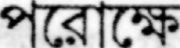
পরোক্ষে
